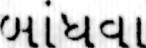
બાંધવા
